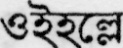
ওইহল্লে
